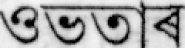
ওভতাৰ
